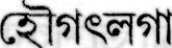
হৌগৎলগা
